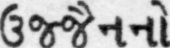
ઉજ્જૈનનો
